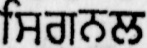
ਸਿਗਨਲ
